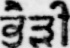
ਭੈੜੀ
